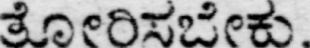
ತೋರಿಸಬೇಕು.
